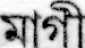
মাগী
